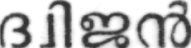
ദ്വിജന്‍
